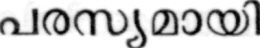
പരസ്യമായി
